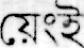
য়েংই
